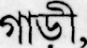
গাড়ী,
